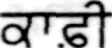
ਕਾਫ਼ੀ
